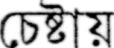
চেষ্টায়
